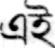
এই
